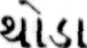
થોડા
